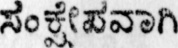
ಸಂಕ್ಷೇಪವಾಗಿ
